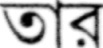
তার
